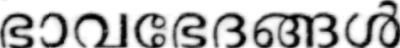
ഭാവഭേദങ്ങള്‍
